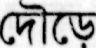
দৌড়ে
